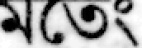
মতেং
